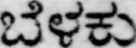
ಬೆಳಕು
